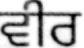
ਵੀਰ
